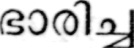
ഭാരിച്ച
